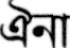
ঐনা
